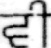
ਵੀ
